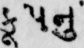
કૂપનું
